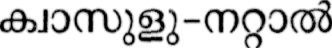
ക്വാസുളു-നറ്റാല്‍
